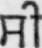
ਸੀ
